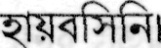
হায়বসিনি।
